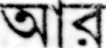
আর
